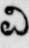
ವಿ
